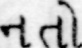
નતો
